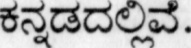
ಕನ್ನಡದಲ್ಲಿವೆ.
